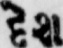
દેશ
